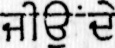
ਜੀਉਂਦੇ
